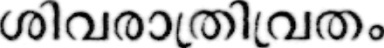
ശിവരാത്രിവ്രതം
